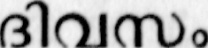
ദിവസം
